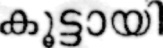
കൂട്ടായി
